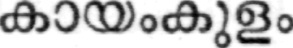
കായംകുളം
